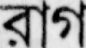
রাগ
